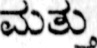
ಮತ್ತು
